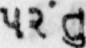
પરંતુ
